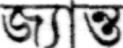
জ্যান্ত
